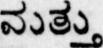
ಮತ್ತು
